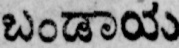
ಬಂಡಾಯ
